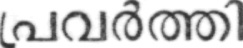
പ്രവര്‍ത്തി
